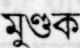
মুণ্ডক
